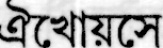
ঐখোয়সে
